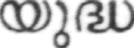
യുദ്ധ
